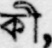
কী,
